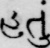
હતું
